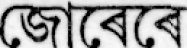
জোৰেৰে
